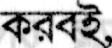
করবই,
